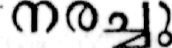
നരച്ചു
